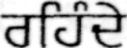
ਰਹਿੰਦੇ
